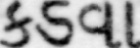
કડવા
